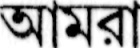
আমরা
